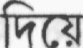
দিয়ে
